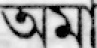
অমা
